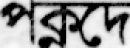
পক্নদে
